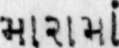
મારામાં
